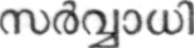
സര്‍വ്വാധി
